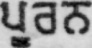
ਪੂਰਨ
